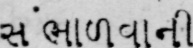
સંભાળવાની
